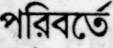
পরিবর্তে
